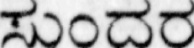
ಸುಂದರ
